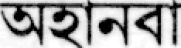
অহানবা
